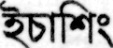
ইচাশিং
